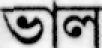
ভাল
